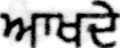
ਆਖਦੇ
